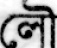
লৌ
